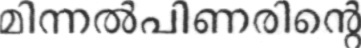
മിന്നല്‍പിണരിന്റെ
